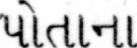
પોતાના
